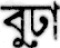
বুঢ়া
